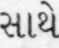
સાથે
